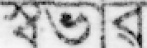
স্বভাৱ
